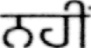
ਨਹੀਂ
